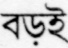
বড়ই
